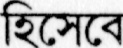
হিসেবে
